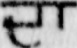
ਦਾ
